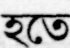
হতে
